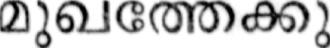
മുഖത്തേക്കു
